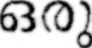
ഒരു
